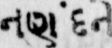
નણંદને
